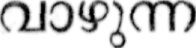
വാഴുന്ന
